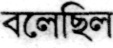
বলেছিল
